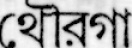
থৌরগা
